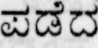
ಪಡೆದ
